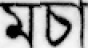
মচা
